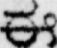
ಈ
